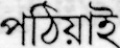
পঠিয়াই
